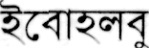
ইবোহলবু
